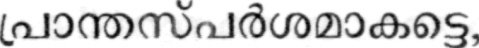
പ്രാന്തസ്പര്‍ശമാകട്ടെ,
